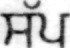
ਸੱਪ
